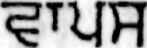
ਵਾਪਸ
